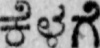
ಕೆಳಗೆ
